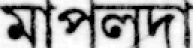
মাপলদা
